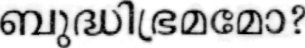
ബുദ്ധിഭ്രമമോ?
